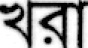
খরা
